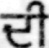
ਦੀ
